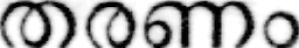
തരണം
